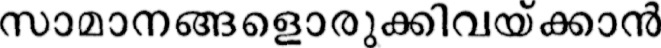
സാമാനങ്ങളൊരുക്കിവയ്ക്കാന്‍
